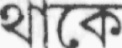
থাকে
